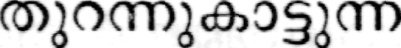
തുറന്നുകാട്ടുന്ന
